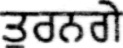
ਤੁਰਨਗੇ
